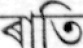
ৰাতি
